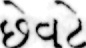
છેવટે
